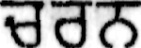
ਚਰਨ
